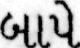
બાપે
